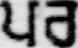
ਪਰ
